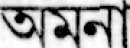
অমনা
